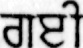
ਗਈ
